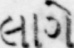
લાગે
